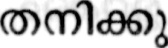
തനിക്കു
